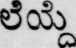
ಲೆಯ್ದೆ
